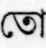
তো
